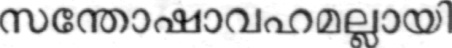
സന്തോഷാവഹമല്ലായി
